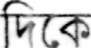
দিকে
